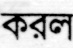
করল
